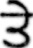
ਤੇ
